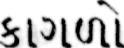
કાગળો
